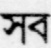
সব
